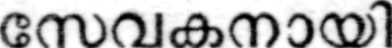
സേവകനായി
